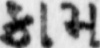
કામ
